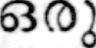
ഒരു
